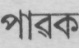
পাৱক
